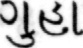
ગુહા
